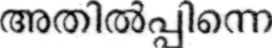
അതില്‍പ്പിന്നെ
